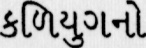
કળિયુગનો
